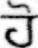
ਹੋ
